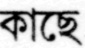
কাছে
